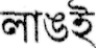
লাঙই
